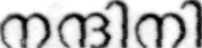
നന്ദിനി
